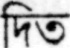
দিত
